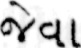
જેવા
